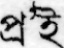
প্র'ই
